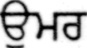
ਉਮਰ
